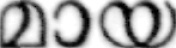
മായ
